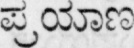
ಪ್ರಯಾಣ
